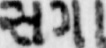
સગા
